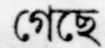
গেছে
